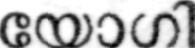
യോഗി
